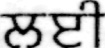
ਲਈ
